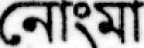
নোংমা
